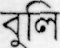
বুলি
